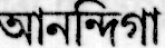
আনন্দিগা
